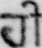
ਹੀ
